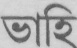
ভাহি
